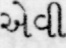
એવી
